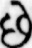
છે
